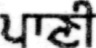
ਪਾਣੀ
